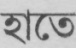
হাতে
